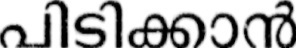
പിടിക്കാന്‍
